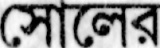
সোলের
